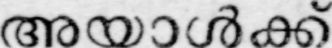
അയാള്‍ക്ക്
